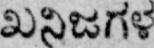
ಖನಿಜಗಳ
